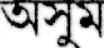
অসুম
